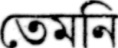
তেমনি
